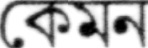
কেমন
